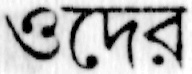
ওদের
